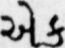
એક
